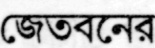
জেতবনের
